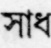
সাধ
